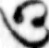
ও
